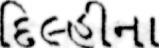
દિલ્હીના
